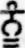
ਨੂੰ
